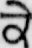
ਕੇ
